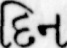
દિન
